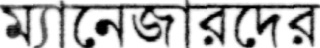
ম্যানেজারদের
